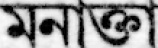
মনাক্তা
